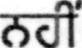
ਨਹੀਂ
